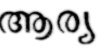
ആര്യ
